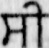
ਸੀ
